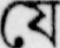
যে
